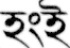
হংই
